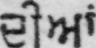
ਦੀਆਂ
